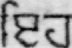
ਇਹ
